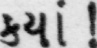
ક્યાં!
